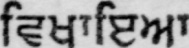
ਵਿਖਾਇਆ
